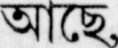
আছে,
